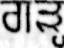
ਗੜ੍ਹ
